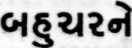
બહુચરને
